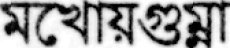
মখোয়গুম্না
